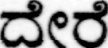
ದೇರೆ
